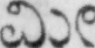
ಮೀ
